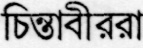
চিন্তাবীররা
